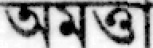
অমত্তা
